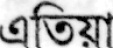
এতিয়া
